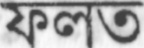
ফলত
